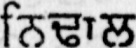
ਨਿਢਾਲ
